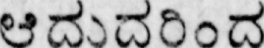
ಆದುದರಿಂದ
